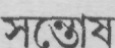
সন্তোষ
